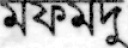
মফমদু
